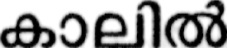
കാലില്‍
